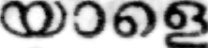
യാളെ
